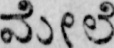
ಮೇಲೆ
